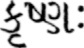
કૃષ્ણઃ
